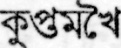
কুপ্তমখৈ
